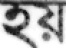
হয়
